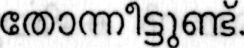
തോന്നീട്ടുണ്ട്.
